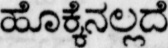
ಹೊಕ್ಕೆನಲ್ಲದೆ
